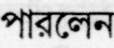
পারলেন
